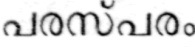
പരസ്പരം
